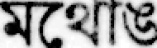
মথোঙ
